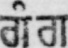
ਗੰਗ
